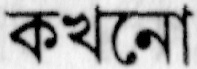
কখনো
